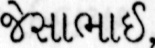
જેસાભાઈ,
